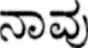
ನಾವು
